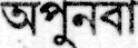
অপুনবা
